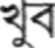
খুব
